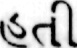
હતી
